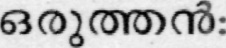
ഒരുത്തന്‍:
